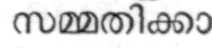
സമ്മതിക്കാ
